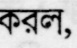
করল,
